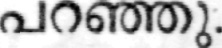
പറഞ്ഞു.
